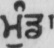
ਮੁੰਡਾ
